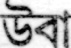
উবা
